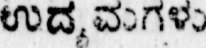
ಉದ್ಯಮಗಳು
